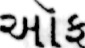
ઑફ
